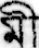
মী
